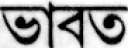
ভাবত
